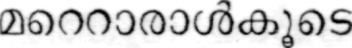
മറെറാരാള്‍കൂടെ
